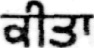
ਕੀਤਾ
